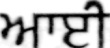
ਆਈ
